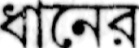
ধানের
